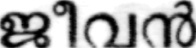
ജീവന്‍
